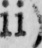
ii)
